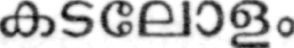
കടലോളം
